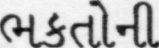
ભક્તોની
